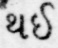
થઈ
